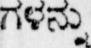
ಗಳನ್ನು
